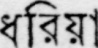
ধরিয়া
